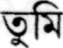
তুমি
